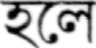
হলে
